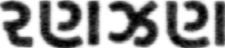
રણઝણ
